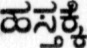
ಹಸ್ತಕ್ಕೆ
